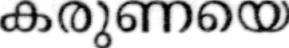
കരുണയെ
